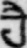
ਹੈ
